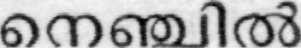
നെഞ്ചില്‍
